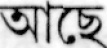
আছে
